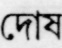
দোষ
